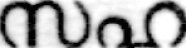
സഹ
